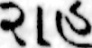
રાહ
